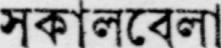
সকালবেলা
